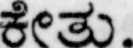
ಕೇತು.
